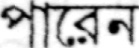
পারেন
